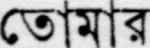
তোমার
